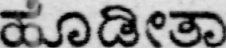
ಹೊಡೀತಾ
